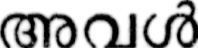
അവള്‍
